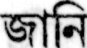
জানি
